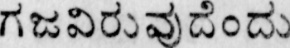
ಗಜವಿರುವುದೆಂದು
